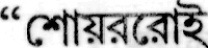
“শোয়ররোই
